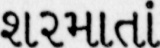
શરમાતાં
